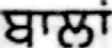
ਬਾਲਾਂ
